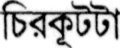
চিরকূটটা
